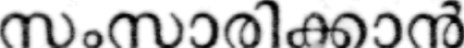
സംസാരിക്കാന്‍
